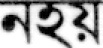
নহয়
